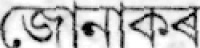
জোনাকৰ
